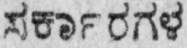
ಸರ್ಕಾರಗಳ
